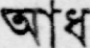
আধ
